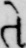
તે
